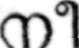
നീ
